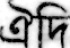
ঐদি
